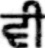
ਵੀ
